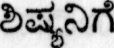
ಶಿಷ್ಯನಿಗೆ
